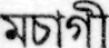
মচাগী
